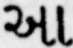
આ
